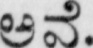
ಅವೆ.
